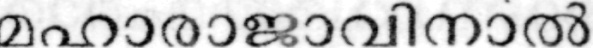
മഹാരാജാവിനാല്‍
